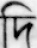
দি
